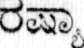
ರಷ್ಯಾ
